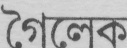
গৈলেক
